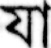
যা
